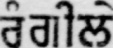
ਰੰਗੀਲੇ
